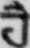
ਹੈ
